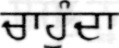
ਚਾਹੁੰਦਾ
